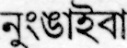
নুংঙাইবা
